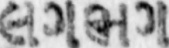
લગભગ
